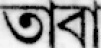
তাবা
